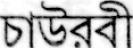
চাউরবী
